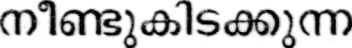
നീണ്ടുകിടക്കുന്ന
